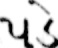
પડે
